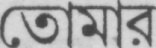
তোমার
